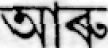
আৰু
